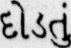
દોડતું
